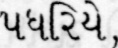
પધરિયે,
